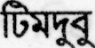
টিমদুবু
